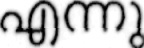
എന്നു
